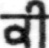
ਕੀ
